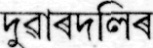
দুৱাৰদলিৰ
